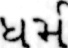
ધર્મ
